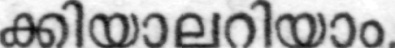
ക്കിയാലറിയാം.
